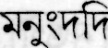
মনুংদদি
